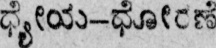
ಧ್ಯೇಯ-ಧೋರಣೆ
